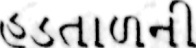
હડતાળની
